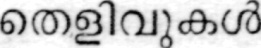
തെളിവുകള്‍
